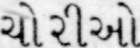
ચોરીઓ
